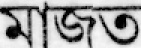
মাজত
